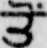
ਤੋਂ
